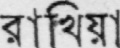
রাখিয়া
